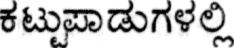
ಕಟ್ಟುಪಾಡುಗಳಲ್ಲಿ
